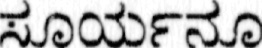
ಸೂರ್ಯನೂ
